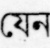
যেন
